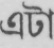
এটা
